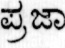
ಪ್ರಜಾ
